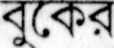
বুকের
